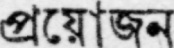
প্রয়োজন
